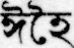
ঈহৈ
